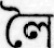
লৈ
